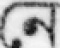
নে
